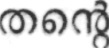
തന്റെ
